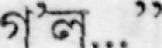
গ'ল..."
